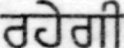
ਰਹੇਗੀ
